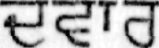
ਦਵਾਰ
